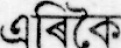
এৰিকৈ
